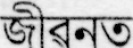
জীৱনত
